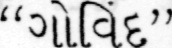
"ગોવિંદ"
